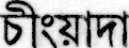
চীংয়াদা
